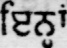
ਇਨ੍ਹਾਂ
